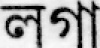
লগা
